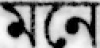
মনে
